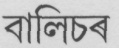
বালিচৰ
